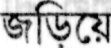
জড়িয়ে
